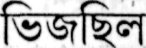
ভিজছিল
